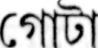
গোটা
